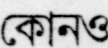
কোনও
